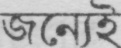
জন্যেই
